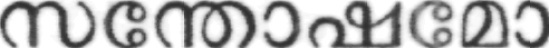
സന്തോഷമോ
